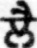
ਲੈ
